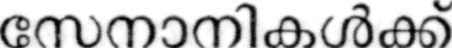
സേനാനികള്‍ക്ക്
